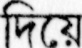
দিয়ে
